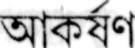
আকর্ষণ
